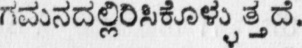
ಗಮನದಲ್ಲಿರಿಸಿಕೊಳ್ಳುತ್ತದೆ.
